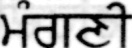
ਮੰਗਣੀ
